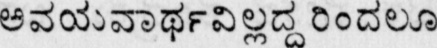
ಅವಯವಾರ್ಥವಿಲ್ಲದ್ದರಿಂದಲೂ
